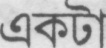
একটা
